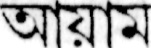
আয়াম
